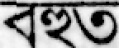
বহুত
